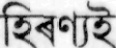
হিৰণ্যই
